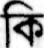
কি
